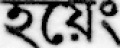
হয়েং
